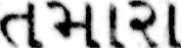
તમારા
